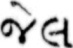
જેલ
